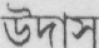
উদাস
